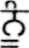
ਨੂੰ
